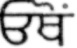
ਓਥੋਂ
